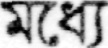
মধ্যে
